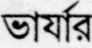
ভার্যার
